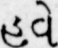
હવે
